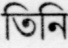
তিনি
